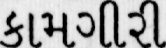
કામગીરી
